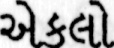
એકલો
